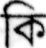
কি
